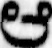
ಆ
